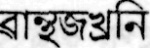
ৱান্থজখ্রনি
